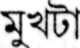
মুখটা
